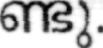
ണ്ടു.
